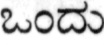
ಒಂದು
